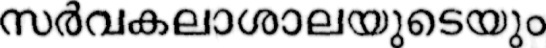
സര്‍വകലാശാലയുടെയും
